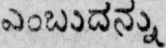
ಎಂಬುದನ್ನು
